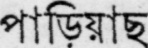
পাড়িয়াছ
